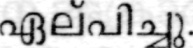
ഏല്പിച്ചു.
